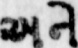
અને
